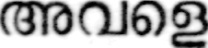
അവളെ
